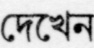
দেখেন
